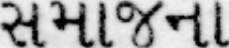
સમાજના
